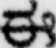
ಈ
